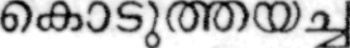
കൊടുത്തയച്ച
